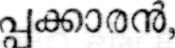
പ്പക്കാരന്‍,
